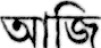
আজি
